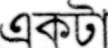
একটা
